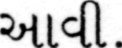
આવી.
